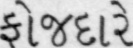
ફોજદારે
